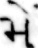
મેં
